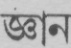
জ্ঞান
